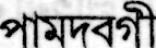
পামদবগী
